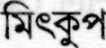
মিৎকুপ
